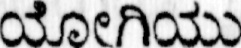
ಯೋಗಿಯು
